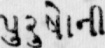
પુરુષોની
